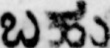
ಬಹು
